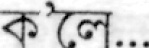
ক'লে...
